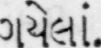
ગયેલાં.
